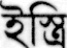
ইস্ত্রি
